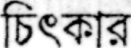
চিৎকার
